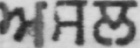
ਅਸਲ
